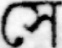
সে
